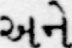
અને
